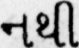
નથી
